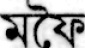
মফৈ
